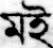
মই
